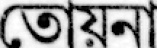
তোয়না
